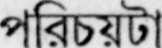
পরিচয়টা
